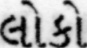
લોકો
